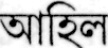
আহিল
